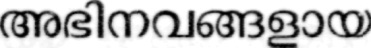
അഭിനവങ്ങളായ
